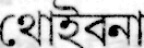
থোইবনা
